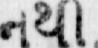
નથી.
